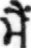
ਮੈਂ
